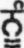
ਨੂੰ
